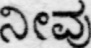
ನೀವು
